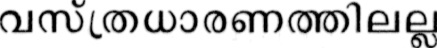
വസ്ത്രധാരണത്തിലല്ല
